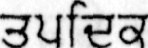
ਤਪਦਿਕ
